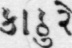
કાઠુરે
